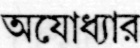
অযোধ্যার
